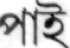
পাই
